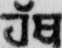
ਹੱਥ
